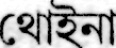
থোইনা
